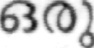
ഒരു
